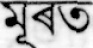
মূৰত
